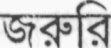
জরুরি
